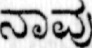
ನಾವು
